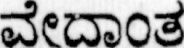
ವೇದಾಂತ
